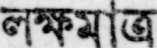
লক্ষমাত্র
